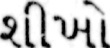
શીખો
